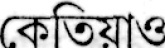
কেতিয়াও
